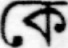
কে
